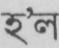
হ'ল
